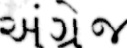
અંગ્રેજ
